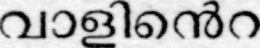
വാളിന്റെ
